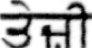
ਤੇਜ਼ੀ
